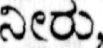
ನೀರು,
